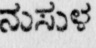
ನುಸುಳ
